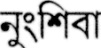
নুংশিবা
